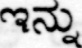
ಇನ್ನು
